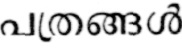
പത്രങ്ങള്‍
